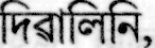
দিৱালিনি,
